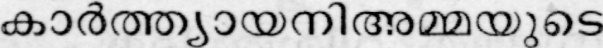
കാര്‍ത്ത്യായനിഅമ്മയുടെ
